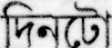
দিনটো
